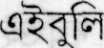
এইবুলি
